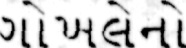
ગોખલેનો
